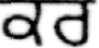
ਕਰ
